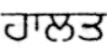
ਹਾਲਤ
